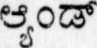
ಅಂಡ್
